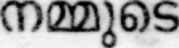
നമ്മുടെ
